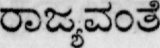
ರಾಜ್ಯವಂತೆ
